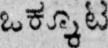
ಒಕ್ಕೂಟ
